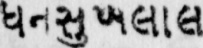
ધનસુખલાલ
